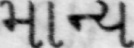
માન્ય
